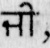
ਜੀ,
